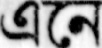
এনে
